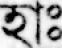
হাঃ
